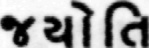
જ્યોતિ
